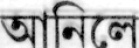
আনিলে
